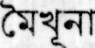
মৈখূনা
